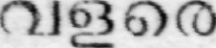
വളരെ
